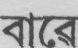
বাৱে
